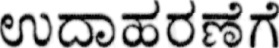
ಉದಾಹರಣೆಗೆ
